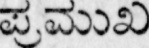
ಪ್ರಮುಖ
